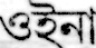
ওইনা
